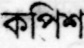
কপিশ
